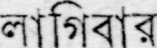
লাগিবার
